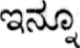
ಇನ್ನೂ
